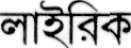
লাইরিক
